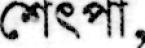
শেৎপা,
